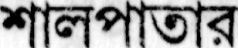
শালপাতার
